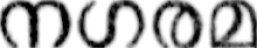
നഗരമ
